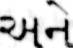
અને
